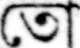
তো
